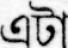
এটা
